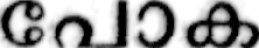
പോക
